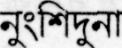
নুংশিদুনা
